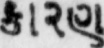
કારણ
